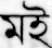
মই
